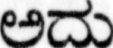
ಅದು
